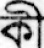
কী
